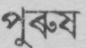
পুৰুষ
